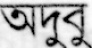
অদুবু
